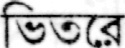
ভিতরে
